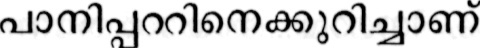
പാനിപ്പററിനെക്കുറിച്ചാണ്
